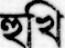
হুখি
